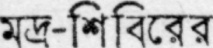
মদ্র-শিবিরের
